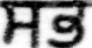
ਸਭ
